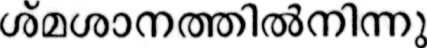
ശ്മശാനത്തില്‍നിന്നു
